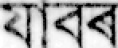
যাবৰ
